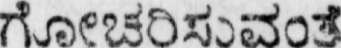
ಗೋಚರಿಸುವಂತೆ
